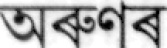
অৰুণৰ
